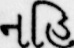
નહિ
